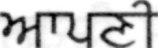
ਆਪਣੀ
